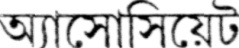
অ্যাসোসিয়েট
